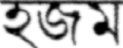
হজম
